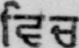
ਵਿਚ
